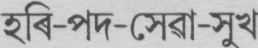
হৰি-পদ-সেৱা-সুখ
